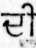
ਦੀ
